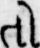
તો
